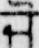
ਜੋ
